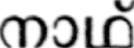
നാഥ്
